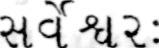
સર્વેશ્વરઃ
